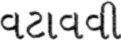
વટાવવી
